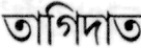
তাগিদাত
